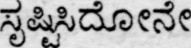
ಸೃಷ್ಟಿಸಿದೋನೇ
